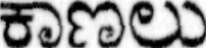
ಕಾಣಲು
